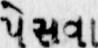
પેસવા
